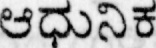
ಆಧುನಿಕ
